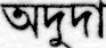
অদুদা
